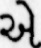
એ
